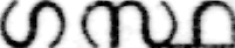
ഗസ്ഥ
